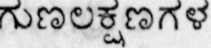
ಗುಣಲಕ್ಷಣಗಳ
